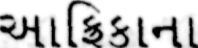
આફ્રિકાના
